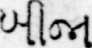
બીજા
